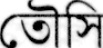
তৌসি
